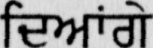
ਦਿਆਂਗੇ
